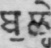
ਬੁਲ੍ਹੇ
